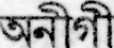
অনীগী
